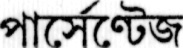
পার্সেণ্টেজ
